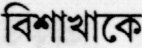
বিশাখাকে
